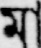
মা
